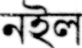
নইল
